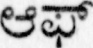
ಆಫ್
